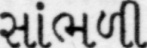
સાંભળી
